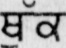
ਥੁੱਕ
